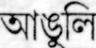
আঙুলি
